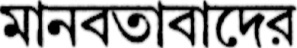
মানবতাবাদের
